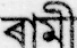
ৰামী
